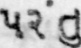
પરંતુ
